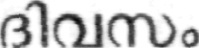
ദിവസം
